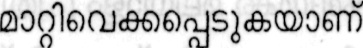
മാറ്റിവെക്കപ്പെടുകയാണ്
